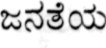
ಜನತೆಯ
